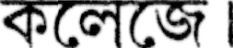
কলেজে।
